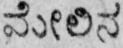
ಮೇಲಿನ
